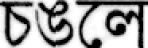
চঙলে
